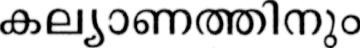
കല്യാണത്തിനും
